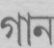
গান
